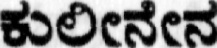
ಕುಲೀನೇನ
